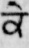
ਕੇ
